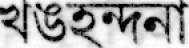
খঙহন্দনা
